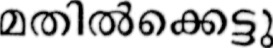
മതില്‍ക്കെട്ടു
